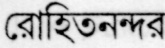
রোহিতনন্দর
